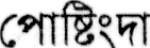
পোষ্টিংদা
